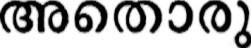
അതൊരു
